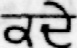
ਕਦੇ
